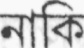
নাকি
